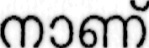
നാണ്
